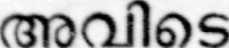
അവിടെ
